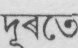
দূৰতে
